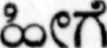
ಹೀಗೆ
